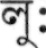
লু:
